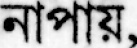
নাপায়,
